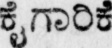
ಕೈಗಾರಿಕೆ
